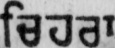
ਚਿਹਰਾ
